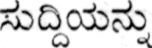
ಸುದ್ದಿಯನ್ನು
